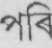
পৰি
